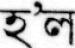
হ'ল
